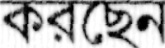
করছেন
